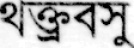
থক্ত্রবসু
